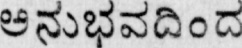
ಅನುಭವದಿಂದ
